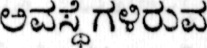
ಅವಸ್ಥೆಗಳಿರುವ
